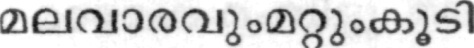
മലവാരവുംമറ്റുംകൂടി
